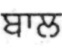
ਬਾਲ
